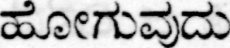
ಹೋಗುವುದು
